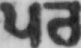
ਪਰ
